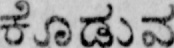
ಕೊಡುವ
